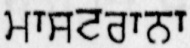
ਮਾਸਟਰਾਨਾ
